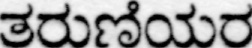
ತರುಣಿಯರ
